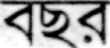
বছর
